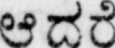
ಆದರೆ
